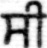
ਸੀ
